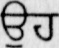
ਉਹ
